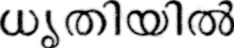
ധൃതിയില്‍
